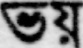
ভয়
